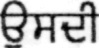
ਉਸਦੀ
